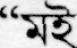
"মই
